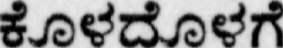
ಕೊಳದೊಳಗೆ
